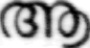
ആ
